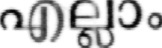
എല്ലാം
